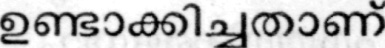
ഉണ്ടാക്കിച്ചതാണ്
